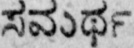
ಸಮರ್ಥ
